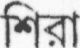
শিরা
